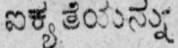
ಐಕ್ಯತೆಯನ್ನು
